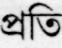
প্রতি
